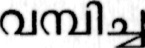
വമ്പിച്ച
